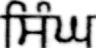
ਸਿੰਘ
